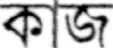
কাজ
